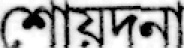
শোয়দনা
